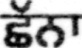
ਛੱਨਾ
